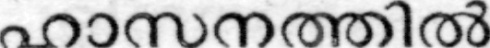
ഹാസനത്തില്‍
